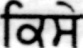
ਕਿਸੇ
